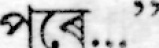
পৰে..."
